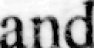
and
